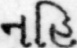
નહિ
